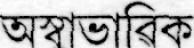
অস্বাভাৱিক
